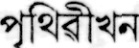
পৃথিৱীখন
